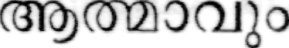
ആത്മാവും
